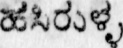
ಹಸಿರುಳ್ಳ
